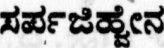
ಸರ್ಪಜಿಹ್ವೇನ
